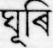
ঘূৰি
